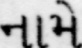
નામે
